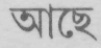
আছে
